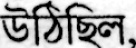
উঠিছিল,
